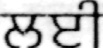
ਲਈ
